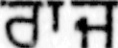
ਰਾਜ
